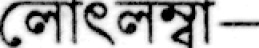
লোৎলম্বা-
